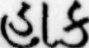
હાક
